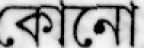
কোনো
